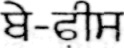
ਬੇ-ਫ਼ੀਸ
